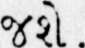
જશે.
